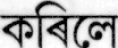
কৰিলে
